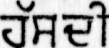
ਹੱਸਦੀ
